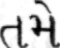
તમે
